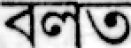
বলত
